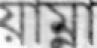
য়াম্না
